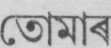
তোমাৰ
